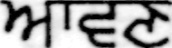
ਆਵਣ
